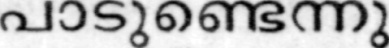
പാടുണ്ടെന്നു
